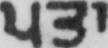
ਪਤਾ
